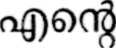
എന്റെ
